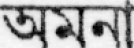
অমনা
